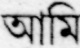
আমি
